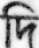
দি
